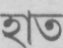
হাত
